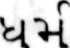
ધર્મ
